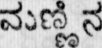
ಮಣ್ಣಿನ
